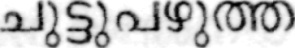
ചുട്ടുപഴുത്ത
